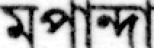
মপান্দা
